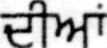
ਦੀਆਂ
